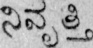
ನಿವೃತ್ತಿ
